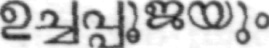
ഉച്ചപ്പൂജയും
